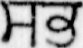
ਸਭ
